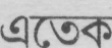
এতেক
